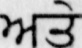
ਅਤੇ
